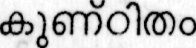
കുണ്ഠിതം
